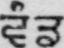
ਵੰਡ
